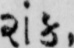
રાંક,
